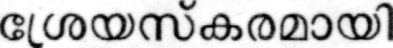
ശ്രേയസ്കരമായി
